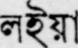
লইয়া
